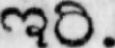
ಇರಿ.
